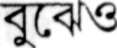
বুঝেও
